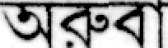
অরুবা
